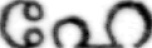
ഹേ
